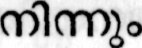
നിന്നും
